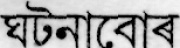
ঘটনাবোৰ
